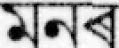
মনৰ
